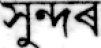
সুন্দৰ
